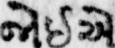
જોઈએ
